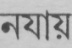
নযায়
